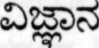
ವಿಜ್ಞಾನ
